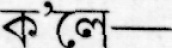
ক'লে-
